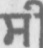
ਸੀ
